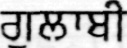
ਗੁਲਾਬੀ
